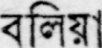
বলিয়া
